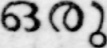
ഒരു
